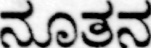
ನೂತನ
